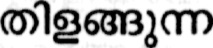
തിളങ്ങുന്ന
